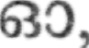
ഓ,
